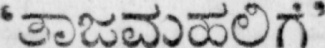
‘ತಾಜಮಹಲಿಗೆ’
